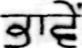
ਭਾਵੇਂ
